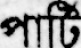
পার্টি
